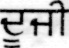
ਦੂਜੀ
